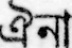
ঐনা
